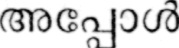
അപ്പോള്‍
